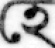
হে
